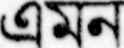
এমন
